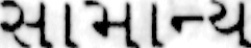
સામાન્ય
